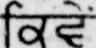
ਕਿਵੇਂ
